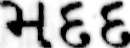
મદદ
